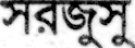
সরজুসু
